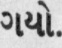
ગયો.
